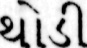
થોડી
